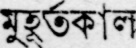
মুহূর্তকাল
